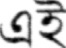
এই
